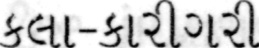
કલા-કારીગરી
